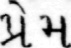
પ્રેમ
